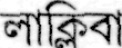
লাক্লিবা
